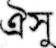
ঐসু
